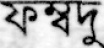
ফম্বদু
